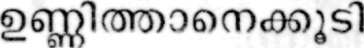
ഉണ്ണിത്താനെക്കൂടി
